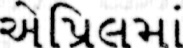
એપ્રિલમાં
